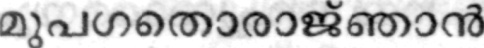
മുപഗതൊരാജ്ഞാന്‍
